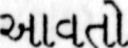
આવતો
